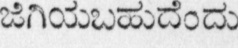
ಜಿಗಿಯಬಹುದೆಂದು
